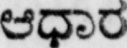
ಆಧಾರ
